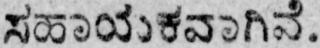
ಸಹಾಯಕವಾಗಿವೆ.
